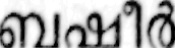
ബഷീര്‍
